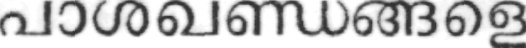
പാശഖണ്ഡങ്ങളെ
